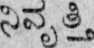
ನಿವೃತ್ತಿ
